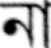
না
